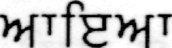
ਆਇਆ
